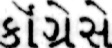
કૉંગ્રેસે
